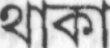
থাকা
